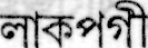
লাকপগী
